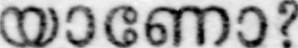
യാണോ?
